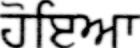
ਹੋਇਆ
